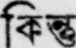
কিন্তু
